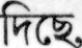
দিছে,
